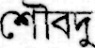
শৌবদু
